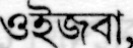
ওইজবা,
